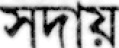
সদায়
